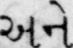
અને
